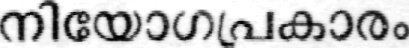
നിയോഗപ്രകാരം
